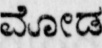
ಮೋಡ
